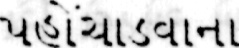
પહોંચાડવાના
